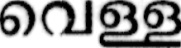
വെള്ള
